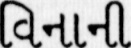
વિનાની
